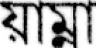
য়াম্না
